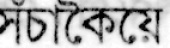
সঁচাকৈয়ে
